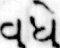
વધે
